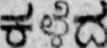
ಕಳೆದ
